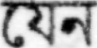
যেন
